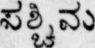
ಪಶ್ಚಿಮ
